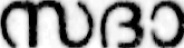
സദാ
